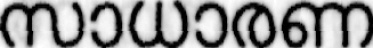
സാധാരണ
